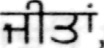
ਜੀਤਾਂ,
